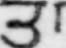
ਤਾ
